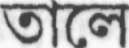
তালে
